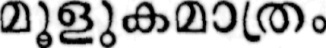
മൂളുകമാത്രം
